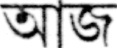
আজ
